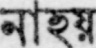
নাহয়
